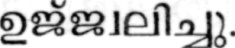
ഉജ്ജ്വലിച്ചു.
